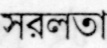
সরলতা
